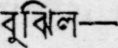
বুঝিল—
